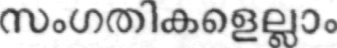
സംഗതികളെല്ലാം
